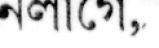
নেলাগে,
